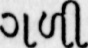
ગળી
